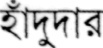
হাঁদুদার
